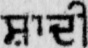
ਸ਼ਾਦੀ
